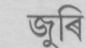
জুৰি
